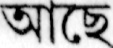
আছে
